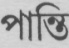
পান্তি
